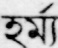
হর্ম্য
